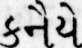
કનૈયે
